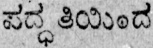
ಪದ್ಧತಿಯಿಂದ
